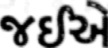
જઈએ
